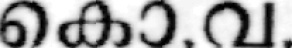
കൊ.വ.
